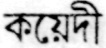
কয়েদী
